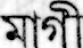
মাগী
